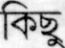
কিছু
